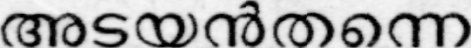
അടയന്‍തന്നെ
